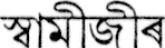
স্বামীজীৰ
